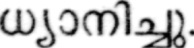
ധ്യാനിച്ചു.
